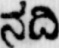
ನದಿ
